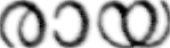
രായ
